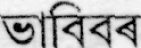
ভাবিবৰ
